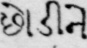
છોડીને
